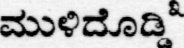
ಮುಳಿದೊಡ್ಡಿಿ
